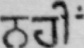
ਨਹੀਂ
